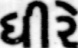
ધીરે
